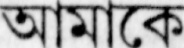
আমাকে
